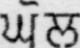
ਘੋਲ
